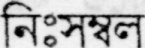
নিঃসম্বল
